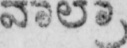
ವಾಲ್ರಾ
